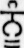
ਨੂੰ
